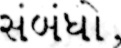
સંબંધો,
